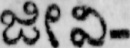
ಜೀವಿ-
